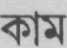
কাম
